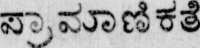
ಪ್ರಾಮಾಣಿಕತೆ
